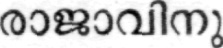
രാജാവിനു
